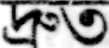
দ্রুত
